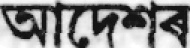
আদেশৰ
